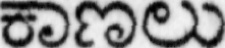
ಕಾಣಲು
